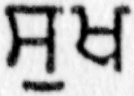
ਸੁਖ
